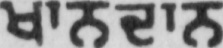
ਖਾਨਦਾਨ
